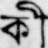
কী
